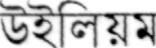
উইলিয়ম
